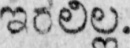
ಇರಲಿಲ್ಲ.
